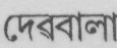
দেৱবালা
